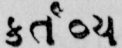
કર્તવ્ય
